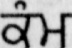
ਕੰਮ
